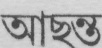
আছন্ত
